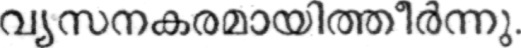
വ്യസനകരമായിത്തീര്‍ന്നു.
